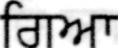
ਗਿਆ
